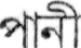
পানী
